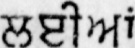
ਲਈਆਂ
